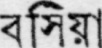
বসিয়া
